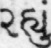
રહ્યું
